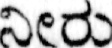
ನೀರು
